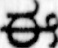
ಈ
